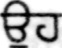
ਉਹ
